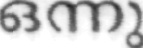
ഒന്നു
